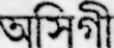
অসিগী
